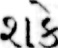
શકે
